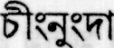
চীংনুংদা
